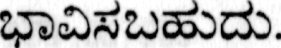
ಭಾವಿಸಬಹುದು.
